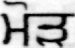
ਮੋੜ
